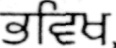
ਭਵਿਖ,
